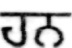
ਹਨ
